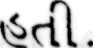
હતી.
